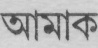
আমাক
